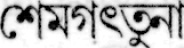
শেমগৎতুনা
